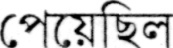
পেয়েছিল
